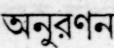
অনুরণন
